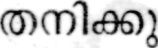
തനിക്കു
